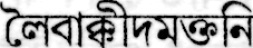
লৈবাক্কীদমক্তনি
